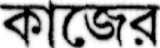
কাজের
